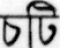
চটি
